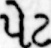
પેટ
